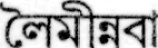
লৈমীন্নবা
